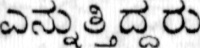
ಎನ್ನುತ್ತಿದ್ದರು
